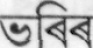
ভৰিৰ
